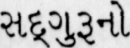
સદગુરૂનો
